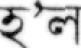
হ'ল
